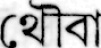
থৌবা
